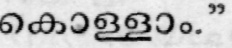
കൊള്ളാം."
